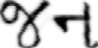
જન
